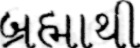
બ્રહ્માથી
